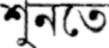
শুনতে
